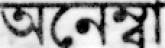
অনেম্বা
